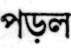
পড়ল
